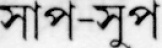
সাপ-সুপ
